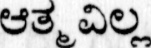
ಆತ್ಮವಿಲ್ಲ
